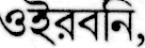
ওইরবনি,
